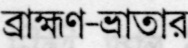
ব্রাহ্মণ-ভ্রাতার
